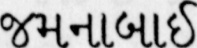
જમનાબાઈ
